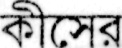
কীসের
